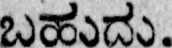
ಬಹುದು.
